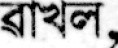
ৱাখল,
